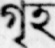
গৃহ
